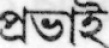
প্ৰভাই
